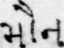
મૌન
